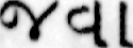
જવા
